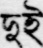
দুই
